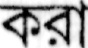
করা
